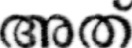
അത്
